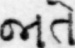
જાતે
